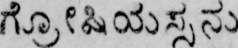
ಗ್ರೋಷಿಯಸ್ಸನು
